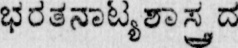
ಭರತನಾಟ್ಯಶಾಸ್ತ್ರದ
